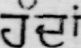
ਹੱਦਾਂ
